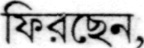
ফিরছেন,
